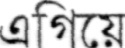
এগিয়ে
